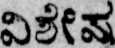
ವಿಶೇಷ
